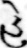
હે
